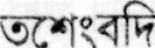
তশেংবদি
